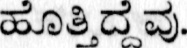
ಹೊತ್ತಿದ್ದೆವು.
